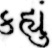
કહ્યું
